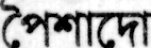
পৈশাদো
